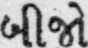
બીજો
